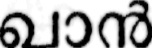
ഖാന്‍
